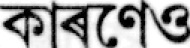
কাৰণেও
